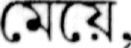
মেয়ে,
